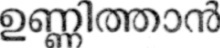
ഉണ്ണിത്താന്‍
